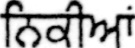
ਨਿਕੀਆਂ
